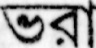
ভরা
